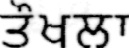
ਤੌਖਲਾ
